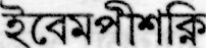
ইবেমপীশক্নি
